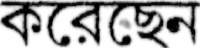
করেছেন
